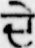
ਦੇ
